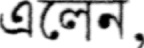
এলেন,
